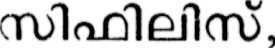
സിഫിലിസ്,
